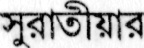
সুরাতীয়ার
